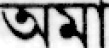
অমা
